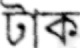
টাক
